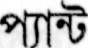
প্যান্ট
